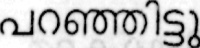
പറഞ്ഞിട്ടു
